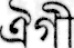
ঐগী
